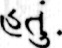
હતું.
